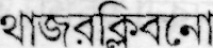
থাজরক্লিবনো
